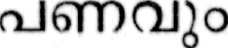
പണവും
